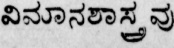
ವಿಮಾನಶಾಸ್ತ್ರವು
